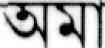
অমা
